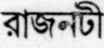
রাজনটী
